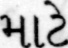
માટે
